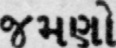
જમણો
